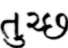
તુચ્છ
